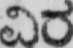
ವಿರ
